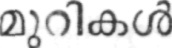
മുറികള്‍
